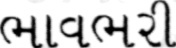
ભાવભરી
